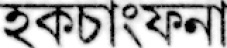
হকচাংফনা
